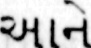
આને
